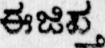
ಈಜಿಪ್ತ
